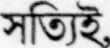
সত্যিই,
